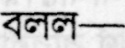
বলল–
